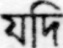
যদি
